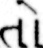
તો
